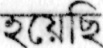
হয়েছি
